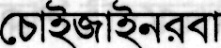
চোইজাইনরবা
